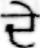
ਦੇ
